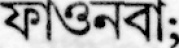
ফাওনবা;
